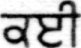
ਕਈ
